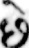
છે
